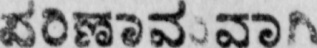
ಪರಿಣಾಮವಾಗಿ
